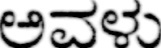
ಅವಳು
